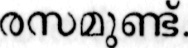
രസമുണ്ട്.
